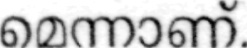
മെന്നാണ്.
